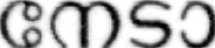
നേടാ
